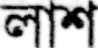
লাশ
